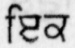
ਇਕ
